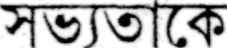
সভ্যতাকে
